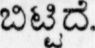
ಬಿಟ್ಟಿದೆ.
